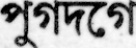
পুগদগে
